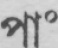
পা
